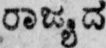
ರಾಜ್ಯದ
